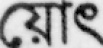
য়োৎ
